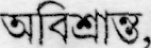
অবিশ্রান্ত,
